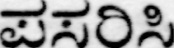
ಪಸರಿಸಿ
